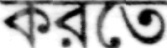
করতে
